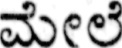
ಮೇಲೆ
